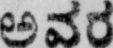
ಅವರ
